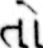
તો
